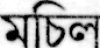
মচিল
